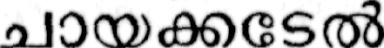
ചായക്കടേല്‍
